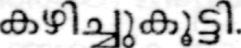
കഴിച്ചുകൂട്ടി.
